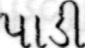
પાડી
